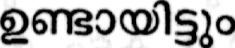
ഉണ്ടായിട്ടും
